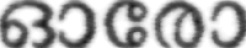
ഓരോ
